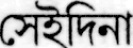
সেইদিনা
